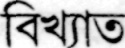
বিখ্যাত
